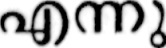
എന്നു
